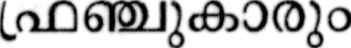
ഫ്രഞ്ചുകാരും
